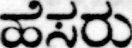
ಹೆಸರು
